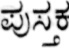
ಪುಸ್ತಕ
